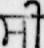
ਸੀ
